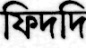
ফিদদি
